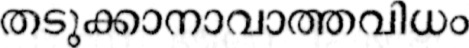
തടുക്കാനാവാത്തവിധം
